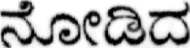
ನೋಡಿದ
